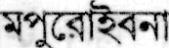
মপুরোইবনা
